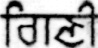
ਗਿਣੀ
